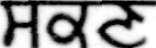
ਸਕਣ
